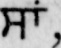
ਸਾਂ,
